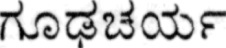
ಗೂಢಚರ್ಯ
